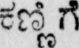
ಕಣ್ಣಿಗೆ
